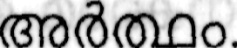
അര്‍ത്ഥം.
